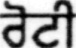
ਰੋਟੀ
